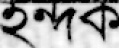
হন্দক
